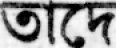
তাদে
